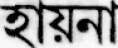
হায়না
